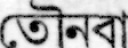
তৌনবা
